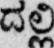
ದಲ್ಲಿ
